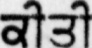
ਕੀਤੀ
